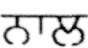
ਨਾਲ
